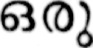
ഒരു
